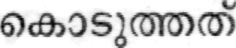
കൊടുത്തത്
